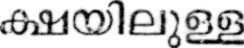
ക്ഷയിലുള്ള
